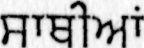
ਸਾਥੀਆਂ
